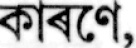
কাৰণে,
